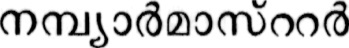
നമ്പ്യാര്‍മാസ്ററര്‍
